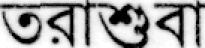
তরাশুবা
